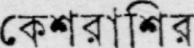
কেশরাশির
